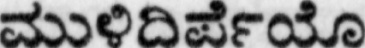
ಮುಳಿದಿರ್ಪೆಯೊ
